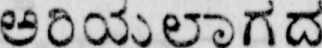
ಅರಿಯಲಾಗದ
